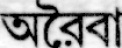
অরৈবা
